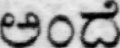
ಅ೦ದೆ
